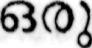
ഒരു
